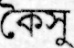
কৈসু
